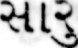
સારુ
